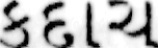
કદાચ
